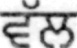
ਵੱਲ
